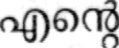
എന്റെ
